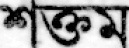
শক্তম
